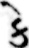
કે
